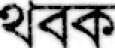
থবক
